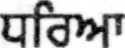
ਧਰਿਆ
